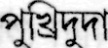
পুখ্রিদুদা
